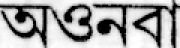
অওনবা
